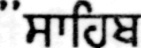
''ਸਾਹਿਬ
